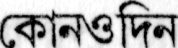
কোনওদিন
